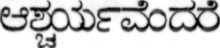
ಆಶ್ಚರ್ಯವೆಂದರೆ
